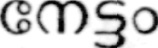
നേട്ടം
